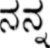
ನನ್ನ
